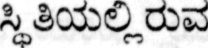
ಸ್ಥಿತಿಯಲ್ಲಿರುವ
